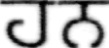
ਹਨ
